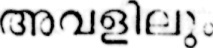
അവളിലും
